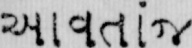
આવતાંજ
